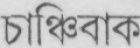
চাঞ্চিবাক
